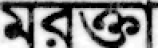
মরক্তা
